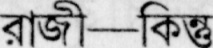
রাজী-কিন্তু
